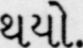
થયો.
